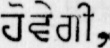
ਹੋਵੇਗੀ,
